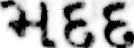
મદદ
